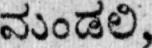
ಮಂಡಲಿ,
